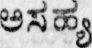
ಅಸಹ್ಯ
